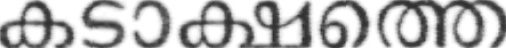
കടാക്ഷത്തെ
